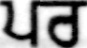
ਪਰ
